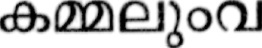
കമ്മലുംവ
